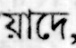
য়াদে,
